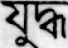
যুদ্ধ
